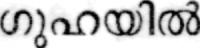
ഗുഹയില്‍
